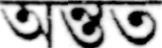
অন্তত
